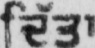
ਦਿੱਤਾ
